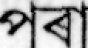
পৰা
